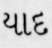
યાદ
